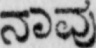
ನಾವು
